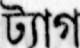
ট্যাগ
